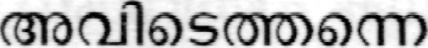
അവിടെത്തന്നെ
